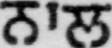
ਨਾਲ
